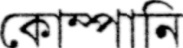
কোম্পানি
